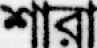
শারা
